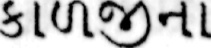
કાળજીના
